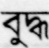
বুদ্ধ
